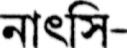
নাৎসি-
